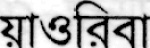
য়াওরিবা
